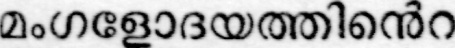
മംഗളോദയത്തിന്റെ
